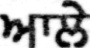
ਆਲੇ
